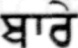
ਬਾਰੇ
